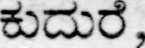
ಕುದುರೆ,
